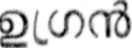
ഉഗ്രന്‍
